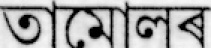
তামোলৰ
